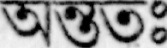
অন্ততঃ
